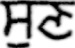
ਸੁਣ
